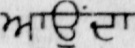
ਆਉਂਦਾ
